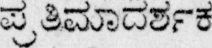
ಪ್ರತಿಮಾದರ್ಶಕ
